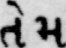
તેમ
